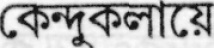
কেন্দুকলায়ে
